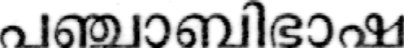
പഞ്ചാബിഭാഷ
